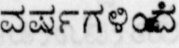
ವರ್ಷಗಳಿಂದ
